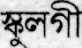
স্কুলগী
